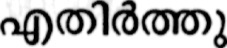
എതിര്‍ത്തു
